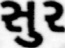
સુર
